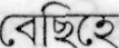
বেছিহে
